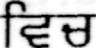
ਵਿਚ
